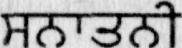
ਸਨਾਤਨੀ
